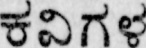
ಕವಿಗಳ
